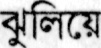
ঝুলিয়ে
